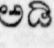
ಅಡಿ
